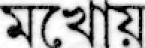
মখোয়
